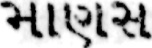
માણસ
